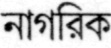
নাগরিক
